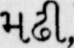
મઢી,
